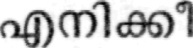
എനിക്കീ
